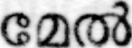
മേല്‍
